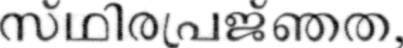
സ്ഥിരപ്രജ്ഞത,
